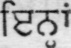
ਇਨ੍ਹਾਂ
